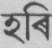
হৰি
